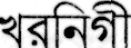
খরনিগী
